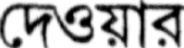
দেওয়ার
